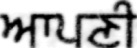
ਆਪਣੀ
